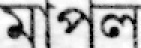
মাপল
